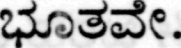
ಭೂತವೇ.
